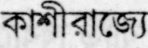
কাশীরাজ্যে
